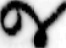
જ
